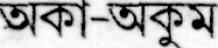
অকা-অকুম
